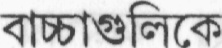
বাচ্চাগুলিকে
